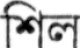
শিল
